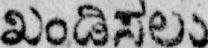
ಖಂಡಿಸಲು
